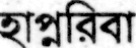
হাপ্নরিবা
